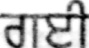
ਗਈ
